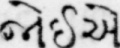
જોઈએ
